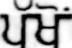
ਪੱਖੋਂ
